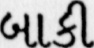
બાકી
